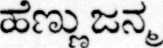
ಹೆಣ್ಣುಜನ್ಮ
